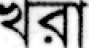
খরা
